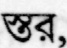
স্তর,
